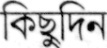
কিছুদিন
